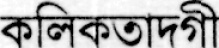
কলিকতাদগী
